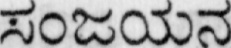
ಸಂಜಯನ
